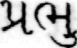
પ્રભુ
